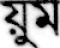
য়ুন
